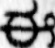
ಈ
